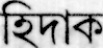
হিদাক
